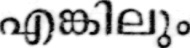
എങ്കിലും
